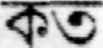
কত
